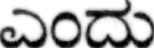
ಎಂದು
